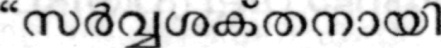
“സര്‍വ്വശക്തനായി
